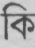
কি
